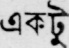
একটু
